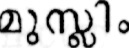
മുസ്ളിം
